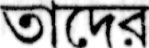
তাদের
